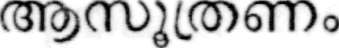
ആസൂത്രണം
